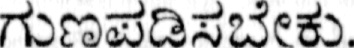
ಗುಣಪಡಿಸಬೇಕು.
